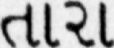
તારા
